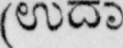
(ಉದಾ
